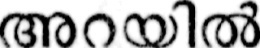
അറയില്‍
